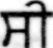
ਸੀ
